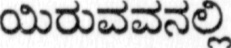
ಯಿರುವವನಲ್ಲಿ
